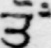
ਤੋਂ
